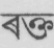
ৰক্ত
